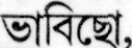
ভাবিছো,
